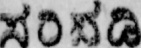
ಸರಿಪಡಿ
